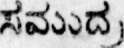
ಸಮುದ್ರ
